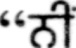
''ਨੀਂ
